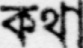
কথা
